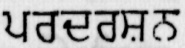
ਪਰਦਰਸ਼ਨ
